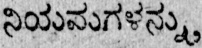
ನಿಯಮಗಳನ್ನು,
